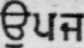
ਉਪਜ
